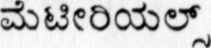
ಮೆಟೀರಿಯಲ್ಸ್
